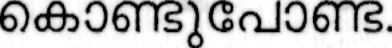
കൊണ്ടുപോണ്ട.
